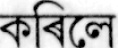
কৰিলে
